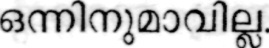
ഒന്നിനുമാവില്ല.
